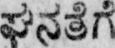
ಘನತೆಗೆ
